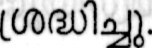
ശ്രദ്ധിച്ചു.
